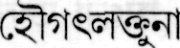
হৌগৎলক্তুনা
